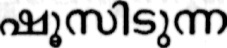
ഷൂസിടുന്ന
